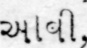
આવી,
